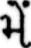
મેં
